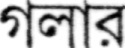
গলার
